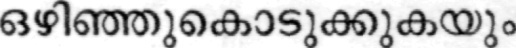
ഒഴിഞ്ഞുകൊടുക്കുകയും
